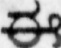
ಈ
